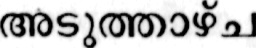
അടുത്താഴ്ച
